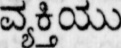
ವ್ಯಕ್ತಿಯು
